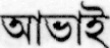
আভাই
